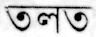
তলত
